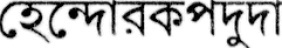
হেন্দোরকপদুদা
